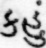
કહું
